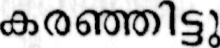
കരഞ്ഞിട്ടു
